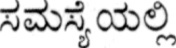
ಸಮಸ್ಯೆಯಲ್ಲಿ
